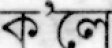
ক'লে
